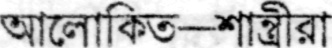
আলোকিত—শান্ত্রীরা
